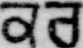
ਕਰ
